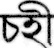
চহী
